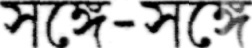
সঙ্গে-সঙ্গে
